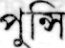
পুন্সি
